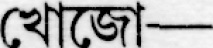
খোজো-
